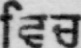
ਵਿਚ
